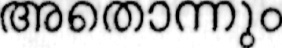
അതൊന്നും
